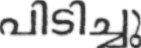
പിടിച്ചു
